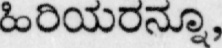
ಹಿರಿಯರನ್ನೂ,
